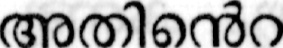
അതിന്റെ
